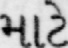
માટે
